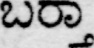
ಬರ್‍ತಾ
